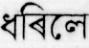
ধৰিলে
